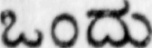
ಒಂದು
